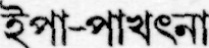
ইপা-পাখৎনা
